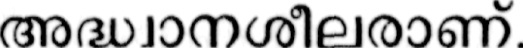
അദ്ധ്വാനശീലരാണ്.
